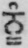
ਨੂੰ
